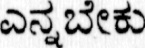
ಎನ್ನಬೇಕು
